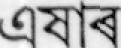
এষাৰ
